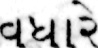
વધારે
